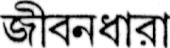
জীবনধারা
